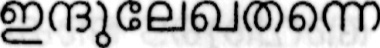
ഇന്ദുലേഖതന്നെ
